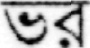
ভর
